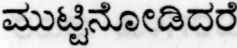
ಮುಟ್ಟಿನೋಡಿದರೆ
